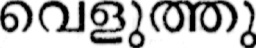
വെളുത്തു
